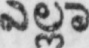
ಎಲ್ಲಾ
